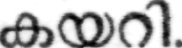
കയറി.
